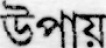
উপায়
